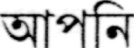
আপনি
